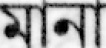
মানা
